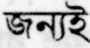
জন্যই
